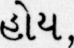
હોય,
